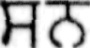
ਸਨ
